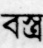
বস্ত্র
